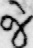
જે
